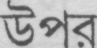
উপর
